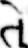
તે
